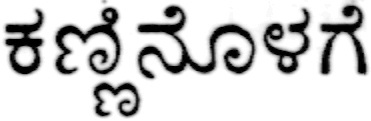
ಕಣ್ಣಿನೊಳಗೆ
